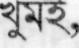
খুমই,
